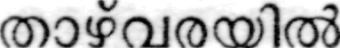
താഴ്വരയില്‍
